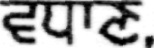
ਵਧਾਣ,
